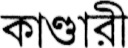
কাণ্ডারী
